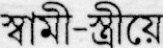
স্বামী-স্ত্রীয়ে
